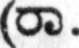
(ರಾ.
